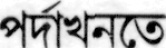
পর্দাখনতে
